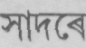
সাদৰে
